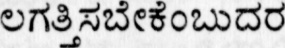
ಲಗತ್ತಿಸಬೇಕೆಂಬುದರ
